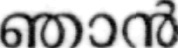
ഞാന്‍
